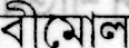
বীমোল
